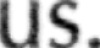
us.
